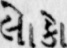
લોકો
